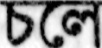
চলে
